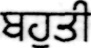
ਬਹੁਤੀ
